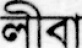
লীবা
